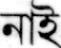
নাই
